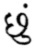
છું
